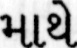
માથે
